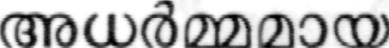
അധര്‍മ്മമായ
